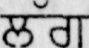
ਲੱਗ
